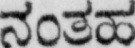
ನಂತಹ
